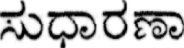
ಸುಧಾರಣಾ
